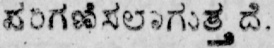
ಪರಿಗಣಿಸಲಾಗುತ್ತದೆ.
